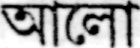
আলো
